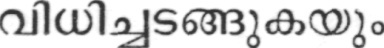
വിധിച്ചടങ്ങുകയും
